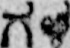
ಗಳ
